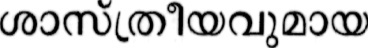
ശാസ്ത്രീയവുമായ
